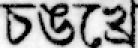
চঙখ্রে
